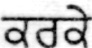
ਕਰਕੇ
